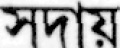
সদায়
